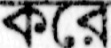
করে
